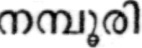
നമ്പൂരി
